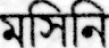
মসিনি
